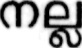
നല്ല
